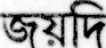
জয়দি
